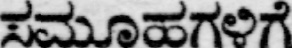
ಸಮೂಹಗಳಿಗೆ
